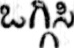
ಒಗ್ಗಿಸಿ
